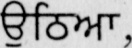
ਉਠਿਆ,
